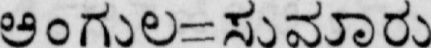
ಅಂಗುಲ=ಸುಮಾರು
